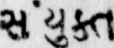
સંયુક્ત
